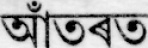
আঁতৰত
